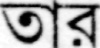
তার
